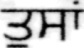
ਤੁਸਾਂ
